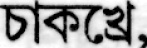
চাকখ্রে,
